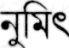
নুমিৎ
